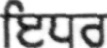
ਇਧਰ
